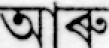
আৰু
